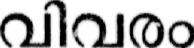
വിവരം
